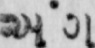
અંગ
